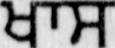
ਖਾਸ
